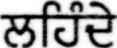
ਲਹਿੰਦੇ
